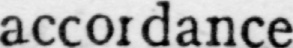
accordance
